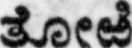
ತೋಱ
